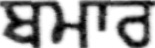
ਬਮਾਰ
